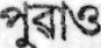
পুৱাও
